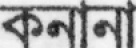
কনানা
